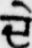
ਦੇ
